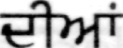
ਦੀਆਂ
